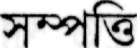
সম্পত্তি
